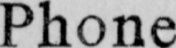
Phone
